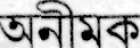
অনীমক
